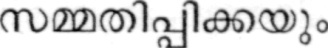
സമ്മതിപ്പിക്കയും
